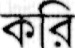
করি
